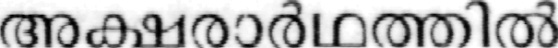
അക്ഷരാര്‍ഥത്തില്‍
